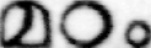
മഠം
